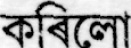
কৰিলো
